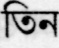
তিন
